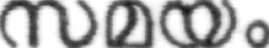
സമയം
